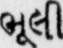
ભૂલી
